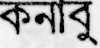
কনাবু
